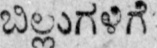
ಬಿಲ್ಲುಗಳಿಗೆ
